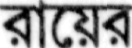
রায়ের
